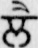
ਲੈ
